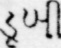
ડૂબી
